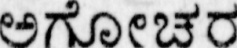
ಅಗೋಚರ
